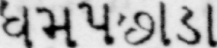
ધમપછાડા
